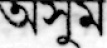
অসুম
